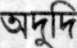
অদুদি
